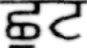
ਛੁਟ
